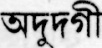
অদুদগী
